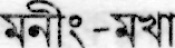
মনীং-মখা
